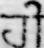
ਹੀ
